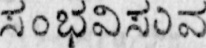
ಸಂಭವಿಸುವ
